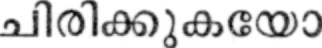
ചിരിക്കുകയോ
